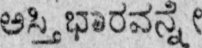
ಅಸ್ತಿಭಾರವನ್ನೇ
